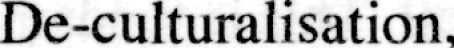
De-culturalisation,
